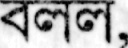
বলল,
